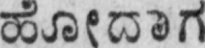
ಹೋದಾಗ
